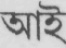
আই
